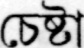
চেষ্টা
